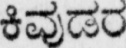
ಕಿವುಡರ
